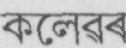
কলেৱৰ
